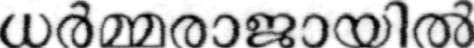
ധര്‍മ്മരാജായില്‍
